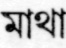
মাথা
